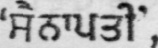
'ਸੈਨਾਪਤੀ',
